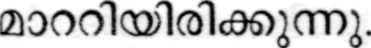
മാററിയിരിക്കുന്നു.
